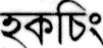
হকচিং
